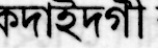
কদাইদগী
